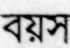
বয়স
